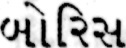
બોરિસ
